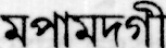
মপামদগী
